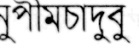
নুপীমচাদুবু
